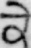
ਕੇ
